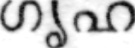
ഗൃഹ
